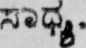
ಸಾಧ್ಯ.
